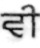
ਵੀ
